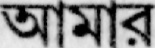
আমার
